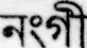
নংগী
